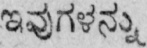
ಇವುಗಳನ್ನು
